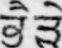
ਭੈੜੇ
